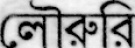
লৌরুরি
